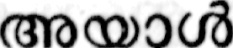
അയാള്‍
